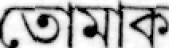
তোমাক
